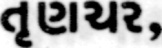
તૃણચર,
